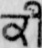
ਕੀ
